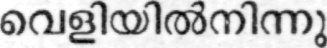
വെളിയില്‍നിന്നു
